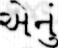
એનું
